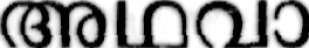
അഥവാ
